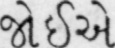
જોઈએ
